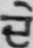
ਦੇ
